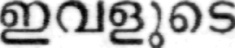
ഇവളുടെ
